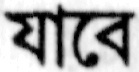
যাবে
